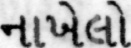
નાખેલો
